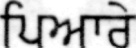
ਪਿਆਰੇ
